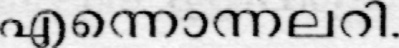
എന്നൊന്നലറി.
